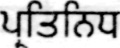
ਪ੍ਰਤਿਨਿਧ
